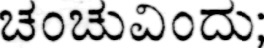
ಚಂಚುವಿಂದು;
